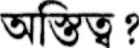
অস্তিত্ব?
